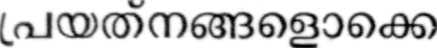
പ്രയത്നങ്ങളൊക്കെ
